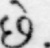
છે.
